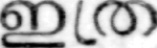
ഇത്ര
